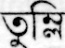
তুম্লি
